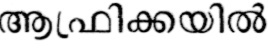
ആഫ്രിക്കയില്‍
